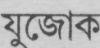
যুজোক
